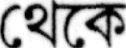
থেকে
